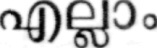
എല്ലാം
